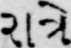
રાત્રે
